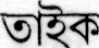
তাইক
